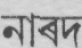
নাৰদ
